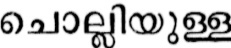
ചൊല്ലിയുള്ള
